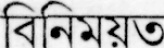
বিনিময়ত
